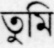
তুমি
